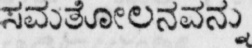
ಸಮತೋಲನವನ್ನು
